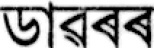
ডাৱৰৰ
